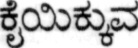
ಕೈಯಿಕ್ಕುವ
